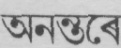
অনন্তৰে
